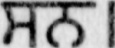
ਸਨ।
